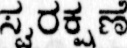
ಸ್ವರಕ್ಷಣೆ
